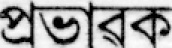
প্রভাৱক
